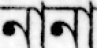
নানা
